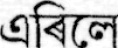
এৰিলে
